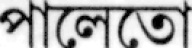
পালেতো
